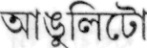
আঙুলিটো
